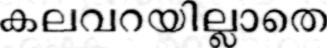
കലവറയില്ലാതെ
